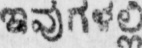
ಇವುಗಳಲ್ಲಿ
